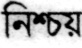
নিশ্চয়
